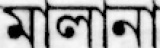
মালানা
